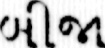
બીજા
